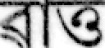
ৱাত্ত
